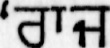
'ਰਾਜ
